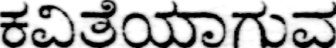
ಕವಿತೆಯಾಗುವ
